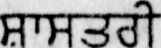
ਸ਼ਾਸਤਰੀ
